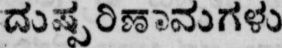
ದುಷ್ಪರಿಣಾಮಗಳು
